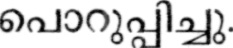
പൊറുപ്പിച്ചു.
